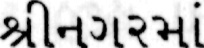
શ્રીનગરમાં
